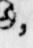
છે,
